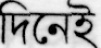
দিনেই
